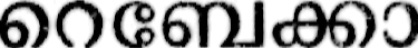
റെബേക്കാ
